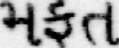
મફત
